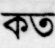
কত
